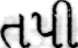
તપી
